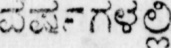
ವರ್ಷಗಳಲ್ಲಿ
